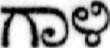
ಗಾಳಿ
